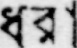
ধরা
